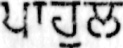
ਪਾਹੁਲ
